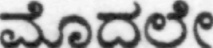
ಮೊದಲೇ
